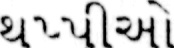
થપ્પીઓ
